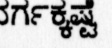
ವರ್ಗಕ್ಕಷ್ಟೆ
